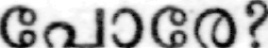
പോരേ?
